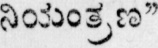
ನಿಯಂತ್ರಣ”
